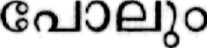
പോലും
